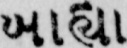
બાહ્યા
